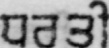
ਧਰਤੀ
